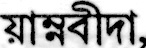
য়াম্নবীদা,
